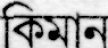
কিমান
